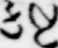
કષ્ટ
